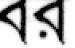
বর
